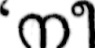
‘നീ
